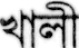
খালী
